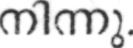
നിന്നു.
